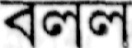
বলল
